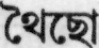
থৈছো
